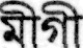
মীগী
